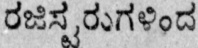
ರಜಿಸ್ಟರುಗಳಿಂದ
